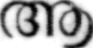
ആ
